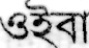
ওইবা
